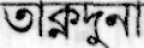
তাক্নদুনা
